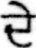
ਦੇ
